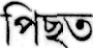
পিছত
